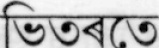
ভিতৰতে
